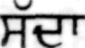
ਸੱਦਾ
